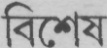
বিশেষ
